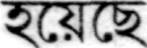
হয়েছে
